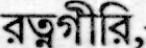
রত্নগীরি,
